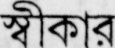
স্বীকার
